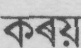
কৰয়
